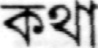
কথা
